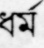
ধর্ম
